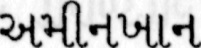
અમીનખાન
